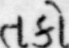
તકો
